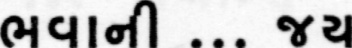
ભવાની.......જય
